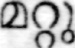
മറ്റു
